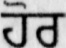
ਹੋਰ
